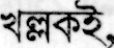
খল্লকই,
